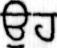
ਉਹ
